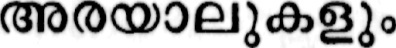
അരയാലുകളും
